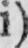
i)
